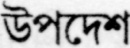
উপদেশ
